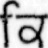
ਕਿ
